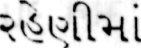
રહેણીમાં
